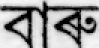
বাৰু
